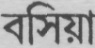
বসিয়া
